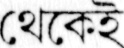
থেকেই
